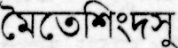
মৈতেশিংদসু
